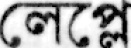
লেপ্লে
